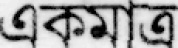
একমাত্র
